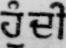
ਹੁੰਦੀ
